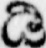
ಡಿ
